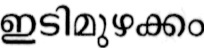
ഇടിമുഴക്കം
